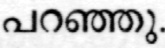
പറഞ്ഞു.
